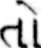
તો
